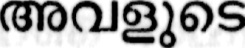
അവളുടെ
